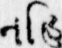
નહિ
